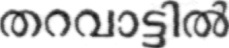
തറവാട്ടില്‍
